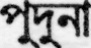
পুদুনা
